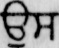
ਉਸ
